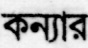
কন্যার
